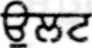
ਉਲਟ
